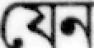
যেন
